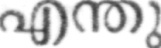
എന്തു
